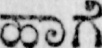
ಹಾಗೆ
